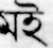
মই
